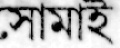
সোমাই
